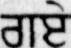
ਗਏ
